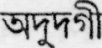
অদুদগী
